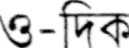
ও-দিক
